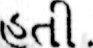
હતી.
